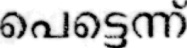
പെട്ടെന്ന്
